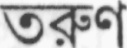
তরুণ
